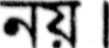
নয়।
